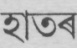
হাতৰ
